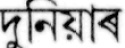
দুনিয়াৰ
